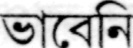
ভাবেনি
